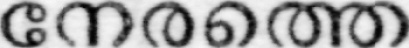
നേരത്തെ
